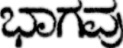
ಭಾಗವು
